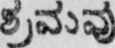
ಶ್ರಮವು
